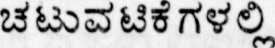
ಚಟುವಟಿಕೆಗಳಲ್ಲಿ
